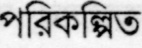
পরিকল্পিত
